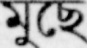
মুছে
